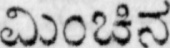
ಮಿಂಚಿನ
